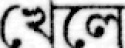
খেলে
